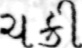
ચક્રી
